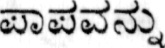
ಪಾಪವನ್ನು
